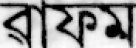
ৱাফম
